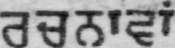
ਰਚਨਾਵਾਂ
